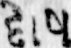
દોષ
